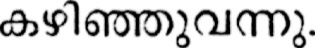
കഴിഞ്ഞുവന്നു.
